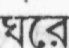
ঘরে
